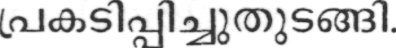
പ്രകടിപ്പിച്ചുതുടങ്ങി.
